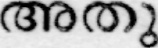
അതു
